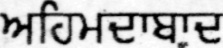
ਅਹਿਮਦਾਬਾਦ
